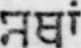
ਸਥਾਂ
